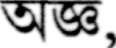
অজ্ঞ,
